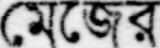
মেজের
